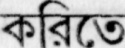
করিতে
